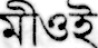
মীওই
